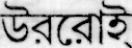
উররোই
